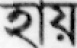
হায়
